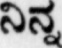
ನಿನ್ನ
